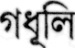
গধূলি
